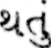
થતું
